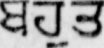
ਬਹੁਤ
